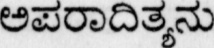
ಅಪರಾದಿತ್ಯನು
